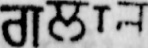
ਗਲਾਸ
